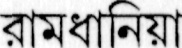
রামধানিয়া
